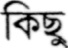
কিছু
